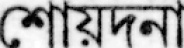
শোয়দনা
